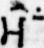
ਮੈਂ
